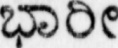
ಭಾರೀ
